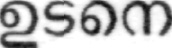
ഉടനെ
